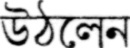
উঠলেন
